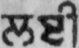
ਲਈ
